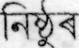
নিষ্ঠুৰ
